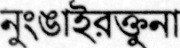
নুংঙাইরক্তুনা
